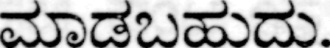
ಮಾಡಬಹುದು.
